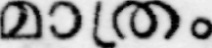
മാത്രം
